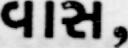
વાસ,
